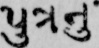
પુત્રનું
